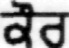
ਕੌਰ
